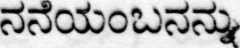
ನನೆಯಂಬನನ್ನು
